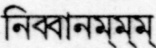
নিব্বানম্ম্ম্
